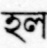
হল
